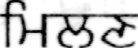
ਮਿਲਣ
